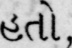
હતો,
